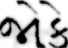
જોકે
